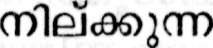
നില്ക്കുന്ന
